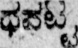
ಧಪಟ್ಟ
